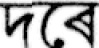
দৰে
